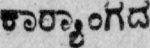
ಕಾರ್‍ಯಾಂಗದ
